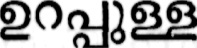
ഉറപ്പുള്ള
